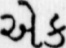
એક
